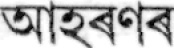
আহৰণৰ
